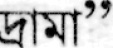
দ্রামা”
